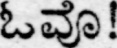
ಓವೊ!
